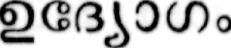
ഉദ്യോഗം
